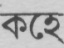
কহে
